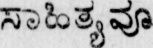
ಸಾಹಿತ್ಯವೂ
